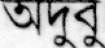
অদুবু
